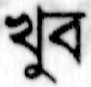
খুব
